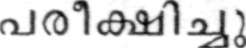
പരീക്ഷിച്ചു
